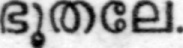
ഭൂതലേ.
